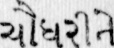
ચૌધરીને
